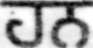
ਹਨ
